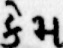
કેમ
